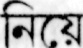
নিয়ে
